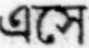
এসে
